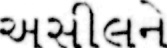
અસીલને
